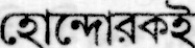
হোন্দোরকই
